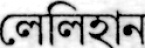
লেলিহান
